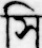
সি
